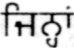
ਜਿਨ੍ਹਾਂ
